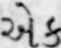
એક
